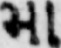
મા
